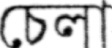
চেলা
